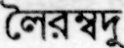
লৈরম্বদু
